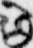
છે
